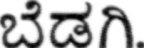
ಬೆಡಗಿ.
